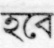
হবে
